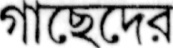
গাছেদের
